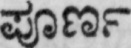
ಪೂರ್ಣ
